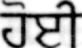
ਹੋਈ
